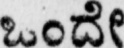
ಒಂದೇ
